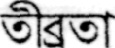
তীব্রতা
